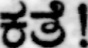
ಕತೆ!
